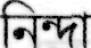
নিন্দা
